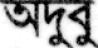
অদুবু
